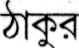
ঠাকুর
